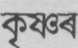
কৃষ্ণৰ
